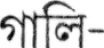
গালি-
